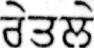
ਰੇਤਲੇ
